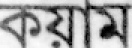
কয়াম
